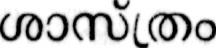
ശാസ്ത്രം
